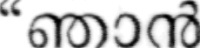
"ഞാന്‍
